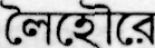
লৈহৌরে
